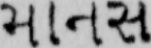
માનસ
